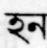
হন
